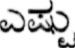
ಎಷ್ಟು
